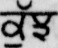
ਕੁੱਝ
